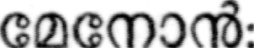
മേനോന്‍:
